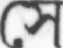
সে
